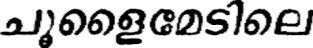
ചൂളൈമേടിലെ
